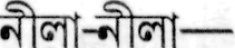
নীলা-নীলা-
